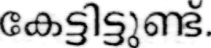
കേട്ടിട്ടുണ്ട്.
